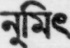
নুমিৎ
